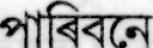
পাৰিবনে
